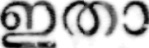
ഇതാ
